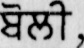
ਬੋਲੀ,
